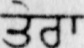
ਤੇਰਾ
